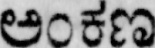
ಅಂಕಣ
